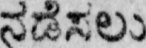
ನಡೆಸಲು
